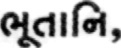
ભૂતાનિ,
